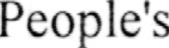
People's
